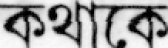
কথাকে
